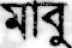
মাবু
